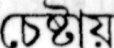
চেষ্টায়
